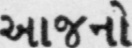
આજનો
